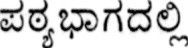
ಪಠ್ಯಭಾಗದಲ್ಲಿ
